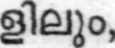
ളിലും,
